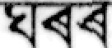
ঘৰৰ
